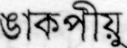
ঙাকপীয়ু
